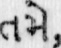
તમે,
